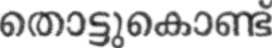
തൊട്ടുകൊണ്ട്
